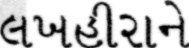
લખહીરાને
